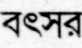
বত্সর
